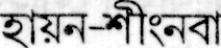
হায়ন-শীংনবা
